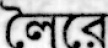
লৈরে
